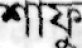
শাফু
